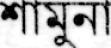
শামুনা
